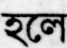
হলে
